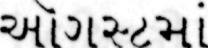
ઑગસ્ટમાં
